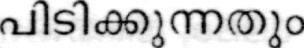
പിടിക്കുന്നതും
